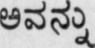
ಅವನ್ನು
